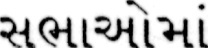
સભાઓમાં
